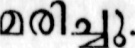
മരിച്ചു.
